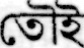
তৌই
